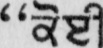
''ਕੋਈ
